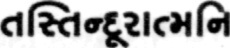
તસ્તિન્દૂરાત્મનિ
